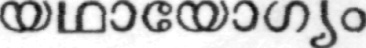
യഥായോഗ്യം
